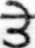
ਤੇ
